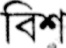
বিশ
